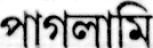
পাগলামি
